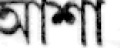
আশা
